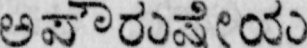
ಅಪೌರುಷೇಯ
